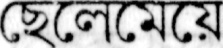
ছেলেমেয়ে
